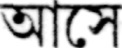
আসে
